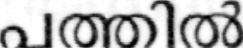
പത്തില്‍
